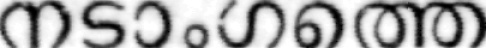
നടാംഗത്തെ
